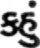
કહું
